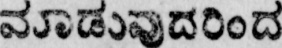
ಮಾಡುವುದರಿಂದ
